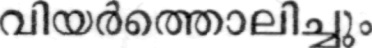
വിയര്‍ത്തൊലിച്ചും
